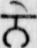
ਨੇ
